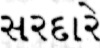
સરદારે
